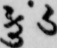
કુંડ
